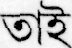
তাই
